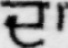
ਦਾ
